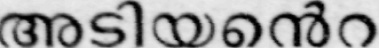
അടിയന്റെ
